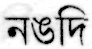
নঙদি
